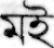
মই
